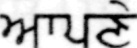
ਆਪਣੇ
